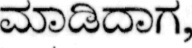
ಮಾಡಿದಾಗ,
